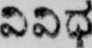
ವಿವಿಧ
